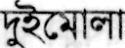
দুইমোলা
